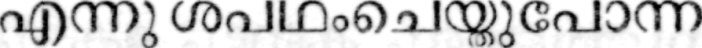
എന്നുശപഥംചെയ്തുപോന്ന
